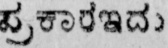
ಪ್ರಕಾರಇದು
